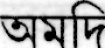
অমদি
